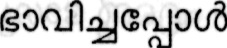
ഭാവിച്ചപ്പോള്‍
